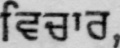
ਵਿਚਾਰ,
